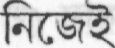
নিজেই
